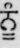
ਨੂੰ
